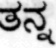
ತನ್ನ
